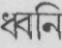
ধ্বনি
